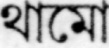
থামো
